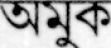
অমুক
